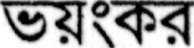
ভয়ংকর
